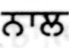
ਨਾਲ
